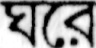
ঘরে
